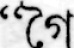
"গৈ
